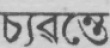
চ্যৱন্তে
